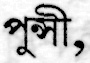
পুন্সী,
